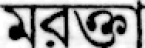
মরক্তা
